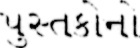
પુસ્તકોનો
